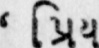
'પ્રિય
